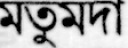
মতুমদা
